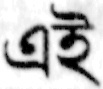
এই
